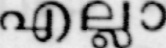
എല്ലാ
